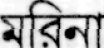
মরিনা
